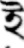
ই
